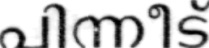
പിന്നീട്
